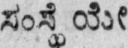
ಸಂಸ್ಥೆಯೇ
